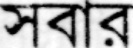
সবার
